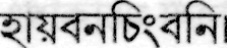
হায়বনচিংবানি।
